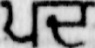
ਪਦ
